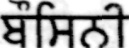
ਬੌਸਿਨੀ
